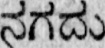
ನಗದು
